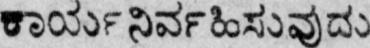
ಕಾರ್ಯನಿರ್ವಹಿಸುವುದು
